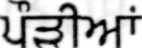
ਪੌੜੀਆਂ
